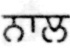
ਨਾਲ
